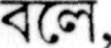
বলে,
